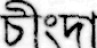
চীংদা
